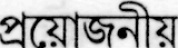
প্রয়োজনীয়
